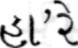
હા`રે
